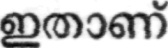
ഇതാണ്
